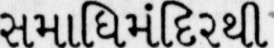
સમાધિમંદિરથી
